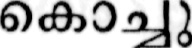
കൊച്ചു
